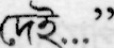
দেই..."
